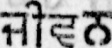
ਜੀਵਨ
